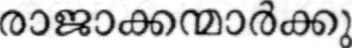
രാജാക്കന്മാര്‍ക്കു
